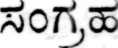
ಸಂಗ್ರಹ
